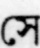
সে
